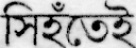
সিহঁতেই
